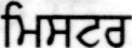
ਮਿਸਟਰ
